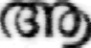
ആ
